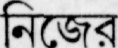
নিজের
